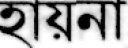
হায়না
